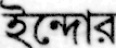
ইন্দোর
